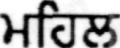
ਮਹਿਲ
